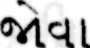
જોવા
